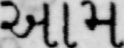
આમ
